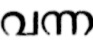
വന്ന
